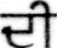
ਦੀ
